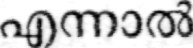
എന്നാല്‍
